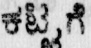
ಕಟ್ಟಿಗೆ
